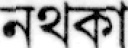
নথকা
